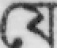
যে
